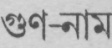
গুণ-নাম
